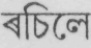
ৰচিলে
